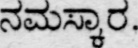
ನಮಸ್ಕಾರ.
